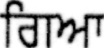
ਗਿਆ
